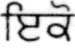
ਇਕੋ
